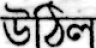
উঠিল
